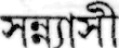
সন্ন্যাসী
